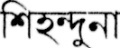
শিহন্দুনা
